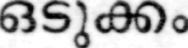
ഒടുക്കം
